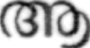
ആ
